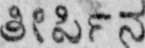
ತೀರ್ಪಿನ
